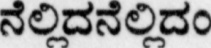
ನೆಲ್ಲಿದನೆಲ್ಲಿದಂ
